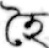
হৈ
